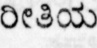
ರೀತಿಯ
